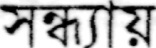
সন্ধ্যায়
